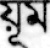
য়ূম
